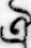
ঐ
